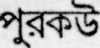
পুরকউ
